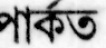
পার্কত
